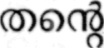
തന്റെ
